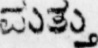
ಮತ್ತು
